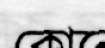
কোনে
